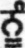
ਨੂੰ
